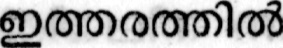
ഇത്തരത്തില്‍
